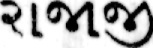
રાજાજી
